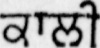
ਕਾਲੀ
